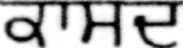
ਕਾਸਦ
